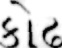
કોઢ
